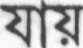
যায়
